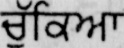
ਚੁੱਕਿਆ
